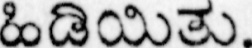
ಹಿಡಿಯಿತು.
